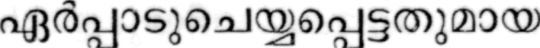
ഏര്‍പ്പാടുചെയ്യപ്പെട്ടതുമായ
